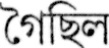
গৈছিল
